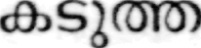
കടുത്ത
